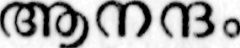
ആനന്ദം
